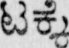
ಟಕ್ಕೆ
